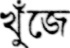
খুঁজে
